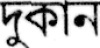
দুকান
